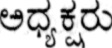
ಅಧ್ಯಕ್ಷರು
